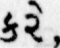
કરે,
